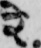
રે.
